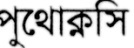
পুথোক্নসি
